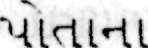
પોતાના
